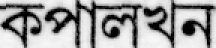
কপালখন
